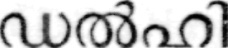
ഡല്‍ഹി
